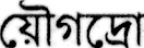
য়ৌগদ্রো
